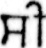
ਸੀ
